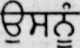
ਉਸਨੂੰ
